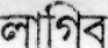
লাগিব
